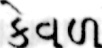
કેવળ
